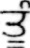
ਤੂੰ
